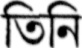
তিনি
